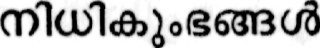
നിധികുംഭങ്ങള്‍
